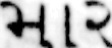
માર
